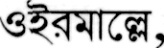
ওইরমাল্লে,
